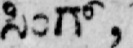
ಸಿಂಗ್,
